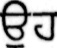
ਉਹ
